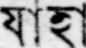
যাহা
